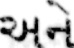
અને
